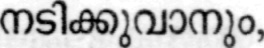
നടിക്കുവാനും,
